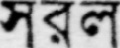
সরল
